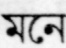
মনে
